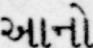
આનો
